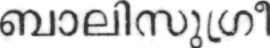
ബാലിസുഗ്രീ
